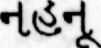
નહનૂ
